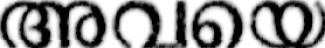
അവയെ
